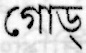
গোড্
